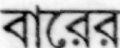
বারের
